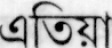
এতিয়া
